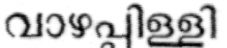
വാഴപ്പിള്ളി
